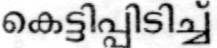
കെട്ടിപ്പിടിച്ച്
